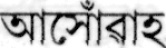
আসোঁৱাহ
